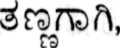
ತಣ್ಣಗಾಗಿ,
